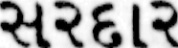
સરદાર
